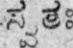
ಸ್ವತಃ
